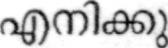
എനിക്കു
